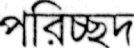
পরিচ্ছদ
